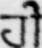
ਹੀ
